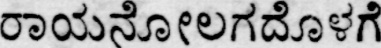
ರಾಯನೋಲಗದೊಳಗೆ
